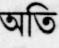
অতি
